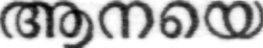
ആനയെ
